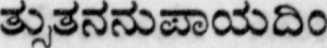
ತ್ಸುತನನುಪಾಯದಿಂ
